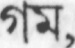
গম,
